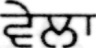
ਵੇਲਾ
